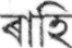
ৰাহি
